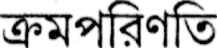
ক্রমপরিণতি
